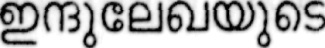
ഇന്ദുലേഖയുടെ
